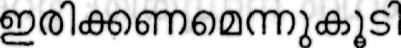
ഇരിക്കണമെന്നുകൂടി
